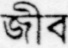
জীব
